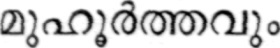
മുഹൂര്‍ത്തവും
